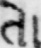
તો
